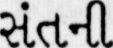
સંતની
